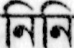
নিনি
